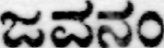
ಜವನಂ
